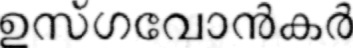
ഉസ്ഗവോന്‍കര്‍
